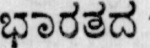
ಭಾರತದ
